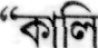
"কালি
